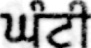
ਘੰਟੀ
